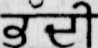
ਭੱਦੀ
